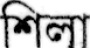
শিলা
